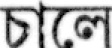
চালে
